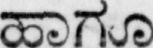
ಹಾಗೂ
